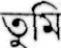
তুমি
